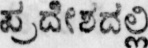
ಪ್ರದೇಶದಲ್ಲಿ
